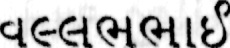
વલ્લભભાઈ
